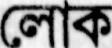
লোক
